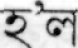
হ'ল
